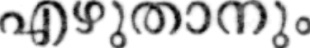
എഴുതാനും
